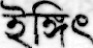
ইঙ্গিৎ
